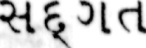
સદગત
